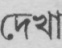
দেখা
